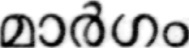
മാര്‍ഗം
